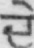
ਦੇ
